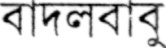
বাদলবাবু
